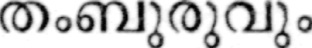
തംബുരുവും
